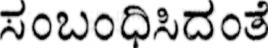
ಸಂಬಂಧಿಸಿದಂತೆ
